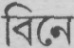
বিনে
